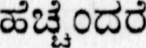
ಹೆಚ್ಚೆಂದರೆ
